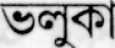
ভলুকা
